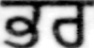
ਭਰ
